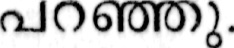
പറഞ്ഞു.
